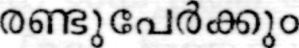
രണ്ടുപേര്‍ക്കും
